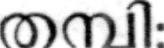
തമ്പി:
